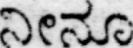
ನೀನೂ
